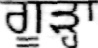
ਗੂੜ੍ਹਾ
